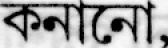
কনানো,
